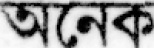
অনেক
